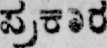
ಪ್ರಕಾರ
